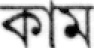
কাম
